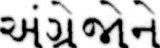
અંગ્રેજોને
